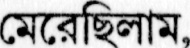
মেরেছিলাম,
